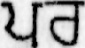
ਪਰ
